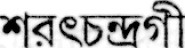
শরৎচন্দ্রগী
